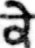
ਕੇ
